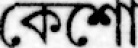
কেশো
